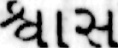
શ્વાસ
